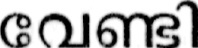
വേണ്ടി
